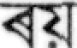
ৰয়
